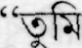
"তুমি
